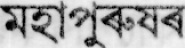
মহাপুৰুষৰ
